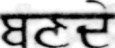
ਬਣਦੇ
